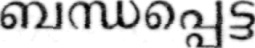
ബന്ധപ്പെട്ട
